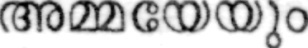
അമ്മയേയും
